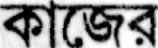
কাজের
